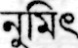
নুমিৎ
